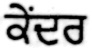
ਕੇਂਦਰ
